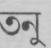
তনু
